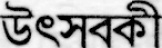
উৎসবকী
